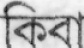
কিবা
